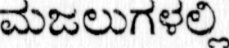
ಮಜಲುಗಳಲ್ಲಿ
